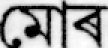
মোৰ
